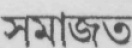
সমাজত
